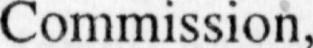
Commission,
